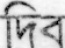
দিব
